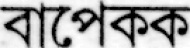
বাপেকক
